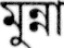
মুন্না
